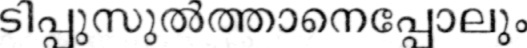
ടിപ്പുസുല്‍ത്താനെപ്പോലും
